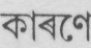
কাৰণে
